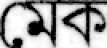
মেক
